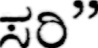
ಸರಿ"
